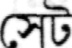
সেট
